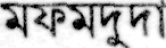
মফমদুদা
